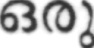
ഒരു
